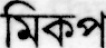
মিকপ
